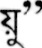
য়ু”
